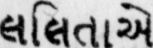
લલિતાએ
